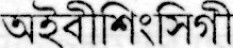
অইবীশিংসিগী
